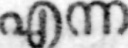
എന്ന
